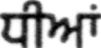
ਧੀਆਂ
